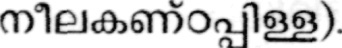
നീലകണ്ഠപ്പിള്ള).
